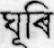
ঘূৰি
